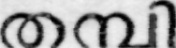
തമ്പി
